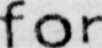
for
